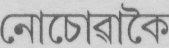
নোচোৱাকৈ
